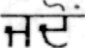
ਜਦੋਂ
